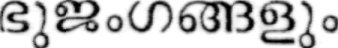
ഭുജംഗങ്ങളും
